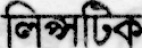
লিপ্সটিক
